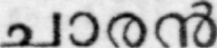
ചാരന്‍
